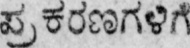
ಪ್ರಕರಣಗಳಿಗೆ
